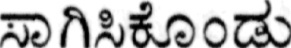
ಸಾಗಿಸಿಕೊಂಡು
